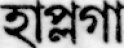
হাপ্লগা
